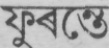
ফুৰন্তে
